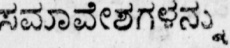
ಸಮಾವೇಶಗಳನ್ನು
